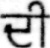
ਦੀ
